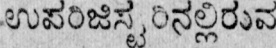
ಉಪರಿಜಿಸ್ಟರಿನಲ್ಲಿರುವ
